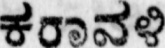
ಕರಾವಳಿ
